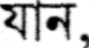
যান,
